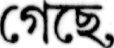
গেছে,
